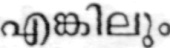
എങ്കിലും
